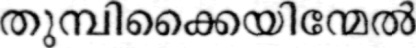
തുമ്പിക്കൈയിന്മേല്‍
